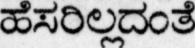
ಹೆಸರಿಲ್ಲದಂತೆ
